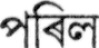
পৰিল
